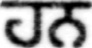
ਹਨ
